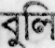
বুলি
